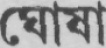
ঘোষা
